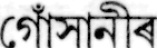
গোঁসানীৰ
